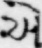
એ
